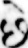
છે
